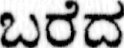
ಬರೆದ
